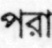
পরা
